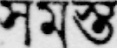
সমস্ত
